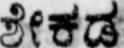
ಶೇಕಡ
